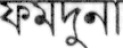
ফমদুনা
